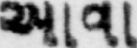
આવા
